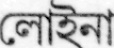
লোইনা
